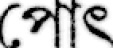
পোৎ
